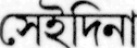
সেইদিনা
